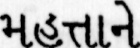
મહત્તાને
